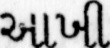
આખી
